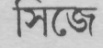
সিজে
